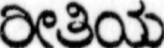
ರೀತಿಯ
